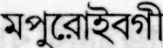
মপুরোইবগী
